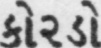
કોરડો
